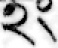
হং
